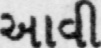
આવી
